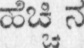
ಹೆಚ್ಚಿನ
